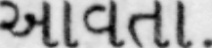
આવતા.
